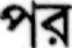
পর
